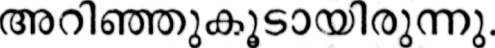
അറിഞ്ഞുകൂടായിരുന്നു.
